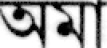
অমা
